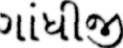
ગાંધીજી
